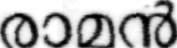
രാമന്‍
